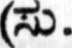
(ಸು.
